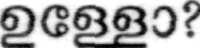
ഉള്ളോ?
